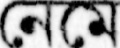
নেমে
